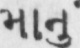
માનું
